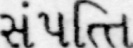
સંપત્તિ
